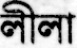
লীলা
